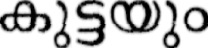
കുട്ടയും
